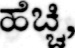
ಹೆಚ್ಚಿ,
